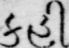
કહી
